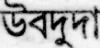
উবদুদা
